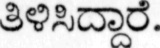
ತಿಳಿಸಿದ್ದಾರೆ.
